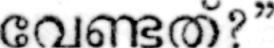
വേണ്ടത്?"
